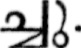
ച്ചു.
